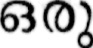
ഒരു
